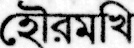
হৌরমখি
